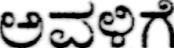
ಅವಳಿಗೆ
